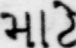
માટે
